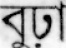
বুঢ়া
